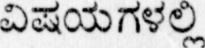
ವಿಷಯಗಳಲ್ಲಿ
